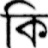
কি
